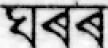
ঘৰৰ
